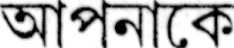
আপনাকে
